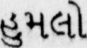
હુમલો
